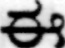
ಈ
